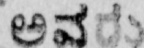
ಅವರು
